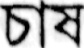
চাষ
